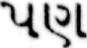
પણ
